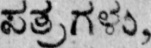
ಪತ್ರಗಳು,
